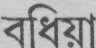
বধিয়া
